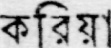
করিয়া
